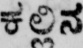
ಕಲ್ಲಿನ
